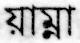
য়াম্না
